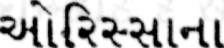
ઓરિસ્સાના
